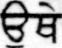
ਉਥੇ
